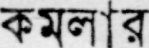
কমলার
